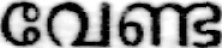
വേണ്ട
